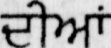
ਦੀਆਂ
